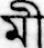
মী
